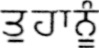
ਤੁਹਾਨੂੰ
